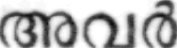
അവര്‍
